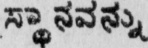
ಸ್ಥಾನವನ್ನು
